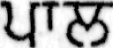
ਪਾਲ
